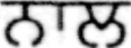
ਨਾਲ
